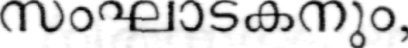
സംഘാടകനും,
